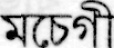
মচেগী
